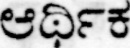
ಆರ್ಥಿಕ
